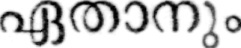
ഏതാനും
